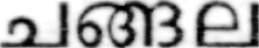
ചങ്ങല
